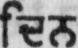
ਦਿਨ
